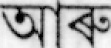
আৰু
